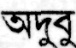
অদুবু
